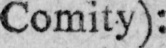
Comity):
